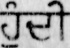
ਹੁੰਦੀ
